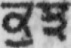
ਕੁਝ
